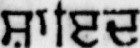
ਸ਼ਾਇਦ
